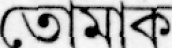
তোমাক
